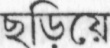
ছড়িয়ে
